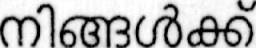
നിങ്ങള്‍ക്ക്
